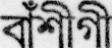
বাঁশীগী
